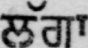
ਲੱਗਾ
